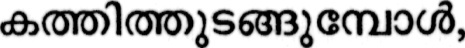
കത്തിത്തുടങ്ങുമ്പോള്‍,
